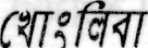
খোংলিবা
